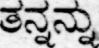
ತನ್ನನ್ನು
